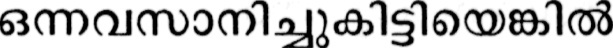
ഒന്നവസാനിച്ചുകിട്ടിയെങ്കില്‍
